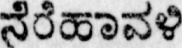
ನೆರೆಹಾವಳಿ
